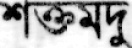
শক্তমদু
